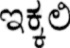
ಇಕ್ಕಲಿ
